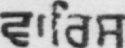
ਵਾਰਿਸ
